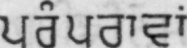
ਪਰੰਪਰਾਵਾਂ
